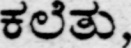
ಕಲೆತು,
